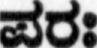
ಪರಃ
